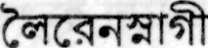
লৈরেনস্নাগী
